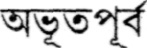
অভূতপূর্ব
